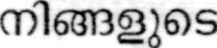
നിങ്ങളുടെ
